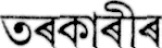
তৰকাৰীৰ
